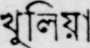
খুলিয়া
